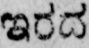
ಇರದ
